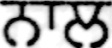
ਨਾਲ
